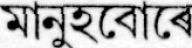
মানুহবোৰে
